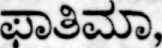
ಫಾತಿಮಾ,
